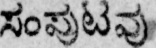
ಸಂಪುಟವು
